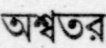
অশ্বতর
